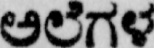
ಅಲೆಗಳ
